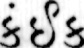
કંઈક
